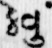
કેવું
